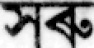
সৰু
